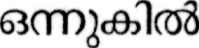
ഒന്നുകില്‍
